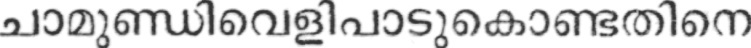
ചാമുണ്ഡിവെളിപാടുകൊണ്ടതിനെ
